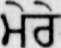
ਮੇਰੇ
